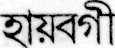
হায়বগী
